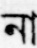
না
